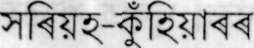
সৰিয়হ-কুঁহিয়াৰৰ
